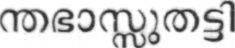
ന്തഭാസ്സുതട്ടി
